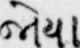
જોયા
